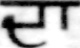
ਦਾ
